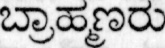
ಬ್ರಾಹ್ಮಣರು
